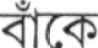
বাঁকে
